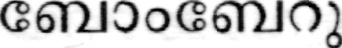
ബോംബേറു
